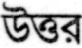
উত্তর
